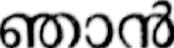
ഞാന്‍
